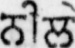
ਨੀਲੇ
